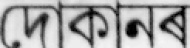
দোকানৰ
